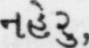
નહેરુ,
